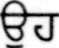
ਉਹ
